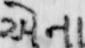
એના
